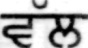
ਵੱਲ
